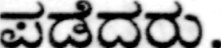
ಪಡೆದರು.
